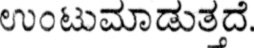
ಉಂಟುಮಾಡುತ್ತದೆ.
